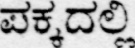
ಪಕ್ಕದಲ್ಲಿ
